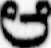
ಆ
